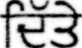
ਦਿੱਤੇ
